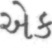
એક
